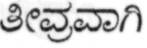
ತೀವ್ರವಾಗಿ
